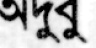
অদুবু
